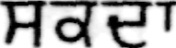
ਸਕਦਾ
